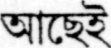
আছেই
